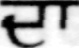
ਦਾ
